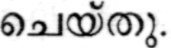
ചെയ്തു.
